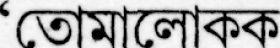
'তোমালোকক
